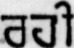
ਰਹੀ
